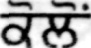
ਕੋਲੋਂ
